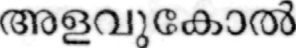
അളവുകോല്‍
